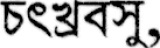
চৎখ্রবসু,
